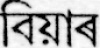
বিয়াৰ
